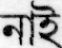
নাই
